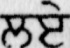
ਲਏ
